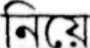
নিয়ে
